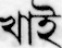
খাই
